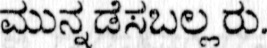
ಮುನ್ನಡೆಸಬಲ್ಲರು.
